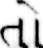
તો
